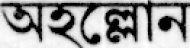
অহল্লোন
